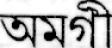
অমগী
